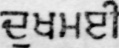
ਦੁਖਮਈ
